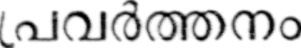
പ്രവര്‍ത്തനം
